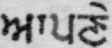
ਆਪਣੇ
